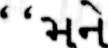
"મને
